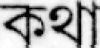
কথা
